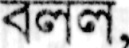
বলল,
